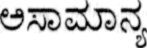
ಅಸಾಮಾನ್ಯ
